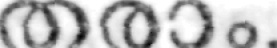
തരാം.
